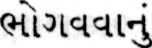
ભોગવવાનું
